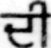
ਦੀ
